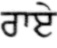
ਰਾਏ
